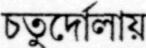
চতুর্দোলায়
